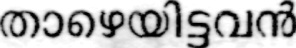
താഴെയിട്ടവന്‍
